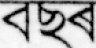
বছৰ
